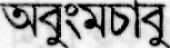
অবুংমচাবু
